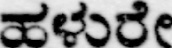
ಹಳುರೇ
